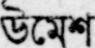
উমেশ
